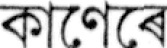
কাণেৰে
